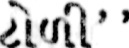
ટોળી"
